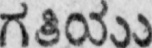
ಗತಿಯು
